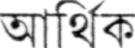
আর্থিক
